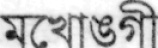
মখোঙগী
